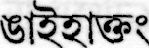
ঙাইহাক্তং
